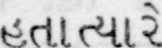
હતાત્યારે
